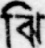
ঝি
